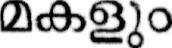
മകളും
